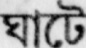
ঘাটে
